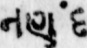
નણંદ
